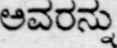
ಅವರನ್ನು
